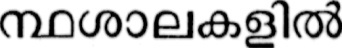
ന്ഥശാലകളില്‍
